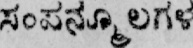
ಸಂಪನ್ಮೂಲಗಳ
